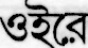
ওইরে
